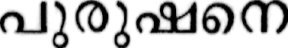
പുരുഷനെ
